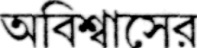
অবিশ্বাসের
